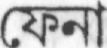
ফেনা
